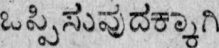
ಒಪ್ಪಿಸುವುದಕ್ಕಾಗಿ
